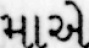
માએ
